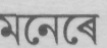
মনেৰে
